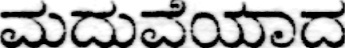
ಮದುವೆಯಾದ
